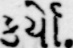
કર્યો.
